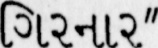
ગિરનાર"
